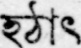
হঠাৎ
